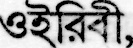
ওইরিবী,
